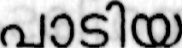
പാടിയ
